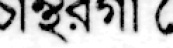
চোন্থরগা
